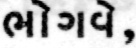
ભોગવે,
